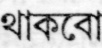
থাকবো
